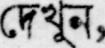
দেখুন,
